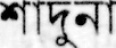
শাদুনা
